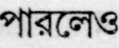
পারলেও
